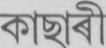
কাছাৰী
